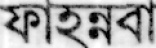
ফাহন্নবা
